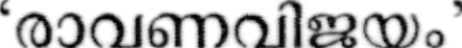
'രാവണവിജയം'
